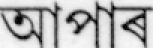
আপাৰ
